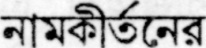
নামকীর্তনের
